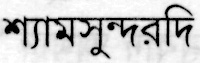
শ্যামসুন্দরদি
